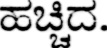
ಹಚ್ಚಿದ.
